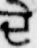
ਦੇ
